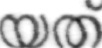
യത്
